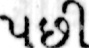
પછી
